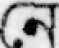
নে
